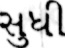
સુધી
